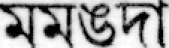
মমঙদা
